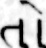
તો
